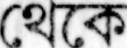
থেকে
